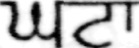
ਘਟਾ
